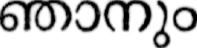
ഞാനും
